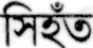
সিহঁত
